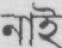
নাই
